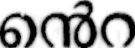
ന്റെ
